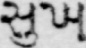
સુખ
